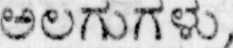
ಅಲಗುಗಳು,
